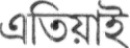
এতিয়াই
